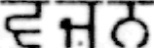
ਵਜ਼ਨ
